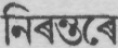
নিৰন্তৰে
